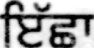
ਇੱਛਾ
